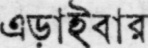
এড়াইবার
